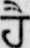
ਹੈ
